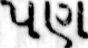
પણ
